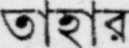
তাহার
